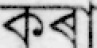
কৰা
